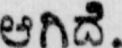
ಆಗಿದೆ.
